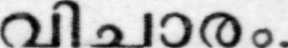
വിചാരം.
